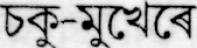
চকু-মুখেৰে
